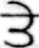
ਤੇ
